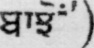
ਬਾਝੋਂ')
